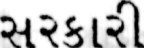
સરકારી
